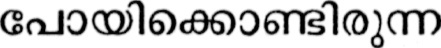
പോയിക്കൊണ്ടിരുന്ന
